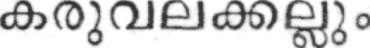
കരുവലക്കല്ലും
